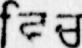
ਵਿਚ
